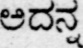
ಅದನ್ನ
